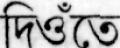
দিওঁতে
